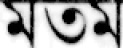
মতম
